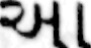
આ
